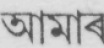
আমাৰ
